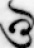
ঔ
